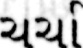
ચર્ચા
